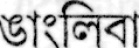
ঙাংলিবা
